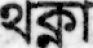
থক্না
